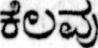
ಕೆಲವು
